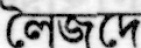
লৈজদে
